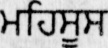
ਮਹਿਸੂਸ
